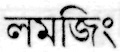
লমজিং
